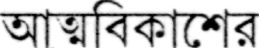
আত্মবিকাশের
